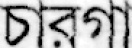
চারগা
